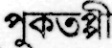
পুকতপ্পী
